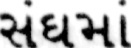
સંઘમાં
